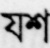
যশ
